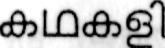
കഥകളി
